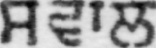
ਸਵਾਲ
